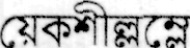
য়েকশীল্লম্লে
